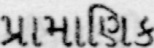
પ્રામાણિક
